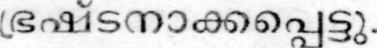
ഭ്രഷ്ടനാക്കപ്പെട്ടു.
